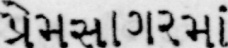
પ્રેમસાગરમાં
